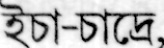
ইচা-চাদ্রে,
